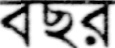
বছর
